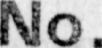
No.
